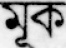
মূক
